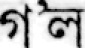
গ'ল
